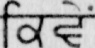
ਕਿਵੇਂ
